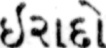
ઇરાદો
